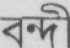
বন্দী
